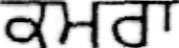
ਕਮਰਾ
